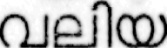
വലിയ
